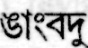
ঙাংবদু
